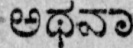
ಅಥವಾ
